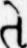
તે
